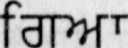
ਗਿਆ
